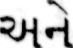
અને
